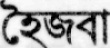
হৈজবা
